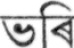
ভৰি
